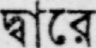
দ্বারে
